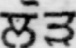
ਲੋੜ
